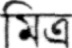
মিত্র
